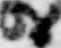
જ
